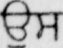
ਉਸ
